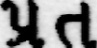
પ્રત
